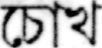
চোখ
